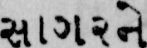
સાગરને
